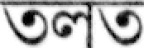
তলত
